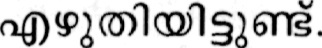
എഴുതിയിട്ടുണ്ട്.
